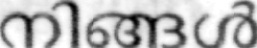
നിങ്ങള്‍
